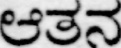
ಆತನ
